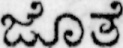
ಜೊತೆ
